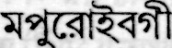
মপুরোইবগী
